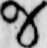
જ
